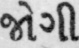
જોગી
